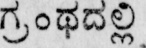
ಗ್ರಂಥದಲ್ಲಿ
